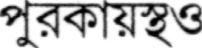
পুরকায়স্থও
